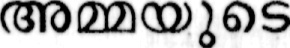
അമ്മയുടെ
